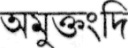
অমুক্তংদি
